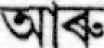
আৰু
